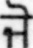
ਜੋ
